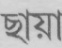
ছায়া
